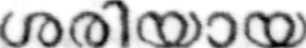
ശരിയായ
